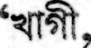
‘খাগী,
